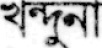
খন্দুনা
